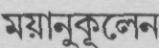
ময়ানুকূলেন
